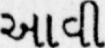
આવી
